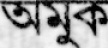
অমুক
